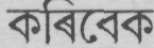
কৰিবেক
